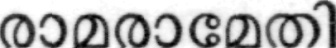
രാമരാമേതി
